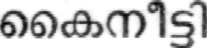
കൈനീട്ടി
